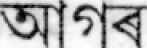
আগৰ
